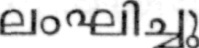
ലംഘിച്ചു
